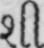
શી
